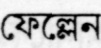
ফেল্লেন
